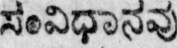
ಸಂವಿಧಾನವು
